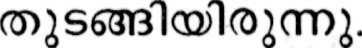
തുടങ്ങിയിരുന്നു.
